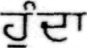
ਹੁੰਦਾ
